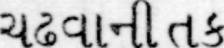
ચઢવાનીતક
